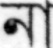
না
